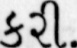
કરી.
